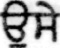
ਉਸੇ
